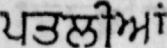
ਪਤਲੀਆਂ
